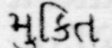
મુક્તિ
